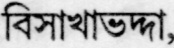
বিসাখাভদ্দা,
